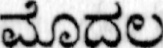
ಮೊದಲ
